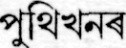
পুথিখনৰ
